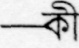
–কী
